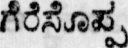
ಗೆರೆಸೊಪ್ಪ
